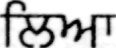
ਲਿਆ
